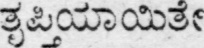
ತೃಪ್ತಿಯಾಯಿತೇ
